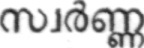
സ്വര്‍ണ്ണ
